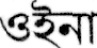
ওইনা
